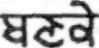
ਬਣਕੇ
